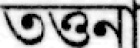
তত্তনা
